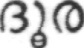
ദൂര
